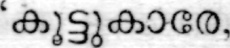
‘കൂട്ടുകാരേ,
